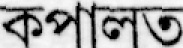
কপালত
